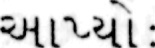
આપ્યોઃ
